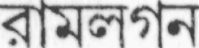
রামলগন
